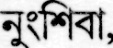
নুংশিবা,
